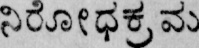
ನಿರೋಧಕ್ರಮ
